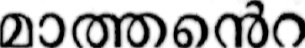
മാത്തന്റെ
